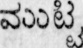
ಮುಟ್ಟಿ
